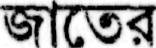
জাতের
